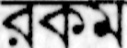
রকম
